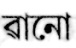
ৱানো
